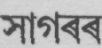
সাগৰৰ
